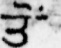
ਤੋਂ
